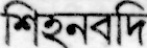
শিহনবদি
